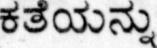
ಕತೆಯನ್ನು
